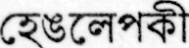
হেঙলেপকী
